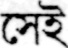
সেই
